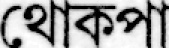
থোকপা
